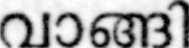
വാങ്ങി
